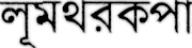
লূমথরকপা
